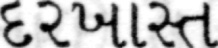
દરખાસ્ત
